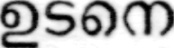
ഉടനെ
